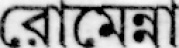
রোমেন্না
